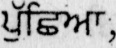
ਪੁੱਛਿਆ,
